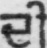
ਦੀ
